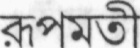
রূপমতী
